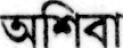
অশিবা
